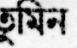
তুমিন
